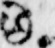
છે.
